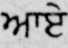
ਆਏ
